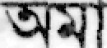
অম
